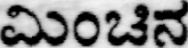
ಮಿಂಚಿನ
